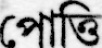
পোত্তি
